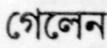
গেলেন
